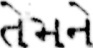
તેમને
